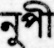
নুপী
